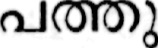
പത്തു
